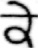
ਕੇ
